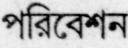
পরিবেশন
